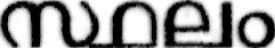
സ്ഥലം
